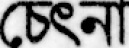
চেৎনা
